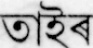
তাইৰ
